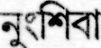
নুংশিবা
